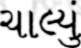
ચાલ્યું
